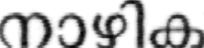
നാഴിക
